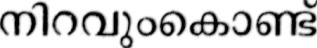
നിറവുംകൊണ്ട്
